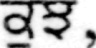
ਕੁਝ,
